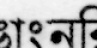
ঙসিদা
